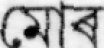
মোৰ
